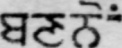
ਬਣਨੋਂ
